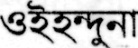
ওইহন্দুনা
